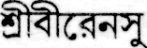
শ্রীবীরেনসু
